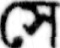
সে
